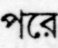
পরে
